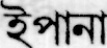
ইপানা
